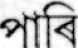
পাৰি
